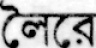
লৈরে
